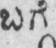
ಬಗ್ಗೆ
